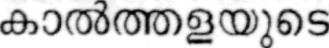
കാല്‍ത്തളയുടെ
